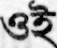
ওই
